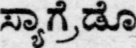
ಸ್ಯಾಗ್ರೆಡೊ
